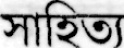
সাহিত্য
